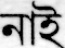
নাই
